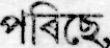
পৰিছে,
